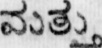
ಮತ್ತು
